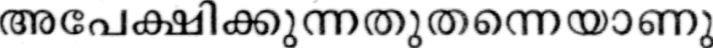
അപേക്ഷിക്കുന്നതുതന്നെയാണു
